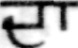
ਦਾ
